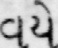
વયે
